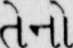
તેનો
